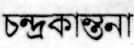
চন্দ্রকান্তনা
